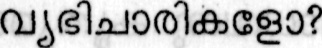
വ്യഭിചാരികളോ?
